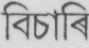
বিচাৰি
